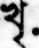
খৃ.
